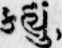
કહ્યું,
